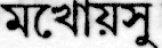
মখোয়সু
